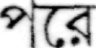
পরে
